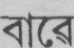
বাৱে
